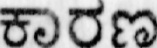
ಕಾರಣ
